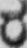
ರ
